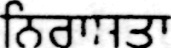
ਨਿਰਾਸਤਾ
